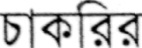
চাকরির
